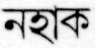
নহাক
